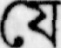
যে
